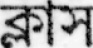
ক্লাস
